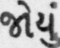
જોયું
